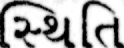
સ્થિતિ
